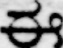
ಈ
